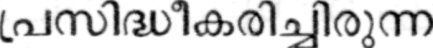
പ്രസിദ്ധീകരിച്ചിരുന്ന
